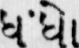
ધંધો
